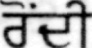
ਰੋਂਦੀ
